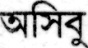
অনীবু
